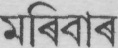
মৰিবাৰ
